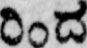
ರಿಂದ
